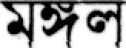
মঙ্গল
